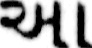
આ
